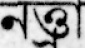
নত্ত্রা
